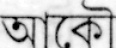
আকৌ
